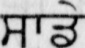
ਸਾਡੇ
